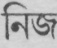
নিজ
